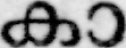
കാ
